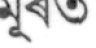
মূৰত
